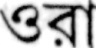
ওরা
